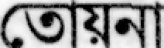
তোয়না
